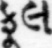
ફૂલ
